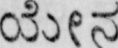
ಯೇನ
